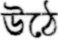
উঠে
